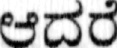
ಆದರೆ
